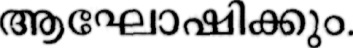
ആഘോഷിക്കും.
